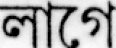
লাগে
